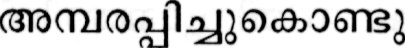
അമ്പരപ്പിച്ചുകൊണ്ടു
